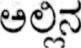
ಅಲ್ಲಿನ
